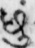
છું
